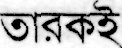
তারকই
